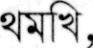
থমখি,
